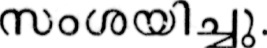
സംശയിച്ചു.
